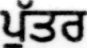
ਪੁੱਤਰ
